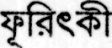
ফূরিৎকী
